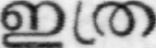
ഇത്ര
